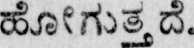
ಹೋಗುತ್ತದೆ.
